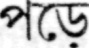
পড়ে
